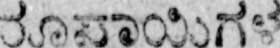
ರೂಪಾಯಿಗಳ
